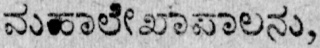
ಮಹಾಲೇಖಾಪಾಲನು,
